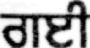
ਗਈ
